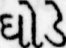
ઘોડે
